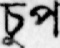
চুপ
